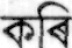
কৰি
